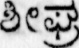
ಶೀಘ್ರ
